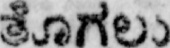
ತೊಗಲು
